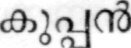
കുപ്പന്‍
